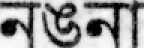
নঙনা
